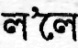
ল'লে
